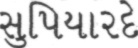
સુપિયારદે
